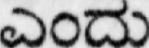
ಎಂದು
